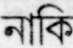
নাকি
